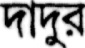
দাদুর
